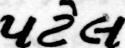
પટેલ
